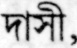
দাসী,
